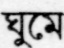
ঘুমে
